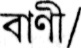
বাণী/
